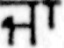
ਜਾ
